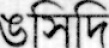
ঙসিদি
